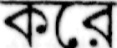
করে
